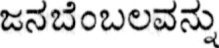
ಜನಬೆಂಬಲವನ್ನು
